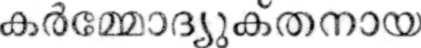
കര്‍മ്മോദ്യുക്തനായ
